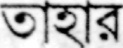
তাহার
